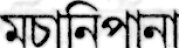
মচানিপানা
